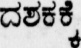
ದಶಕಕ್ಕೆ
